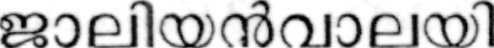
ജാലിയന്‍വാലയി
